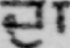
ਦਾ
